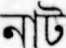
নাট
